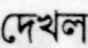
দেখল
